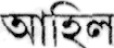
আহিল
